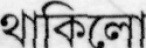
থাকিলো
